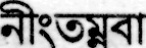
নীংতম্নবা
